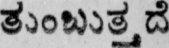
ತುಂಬುತ್ತದೆ
